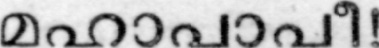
മഹാപാപീ!
